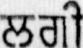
ਲਗੀ
